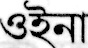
ওইনা
